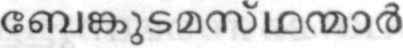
ബേങ്കുടമസ്ഥന്മാര്‍
